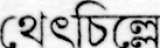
থেৎচিল্লে
